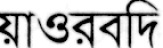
য়াওরবদি
